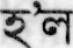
হ'ল
